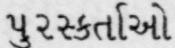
પુરસ્કર્તાઓ
